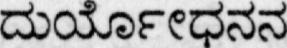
ದುರ್ಯೋಧನನ
